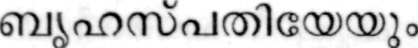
ബൃഹസ്പതിയേയും
